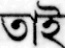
তাই
